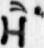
ਮੈਂ
